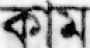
কাম
